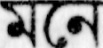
মনে
